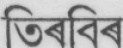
তিৰবিৰ
